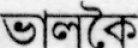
ভালকৈ
